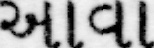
આવા
